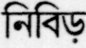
নিবিড়
